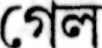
গেল
